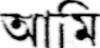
আমি
